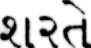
શરતે
